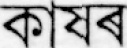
কাষৰ
